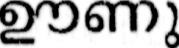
ഊണു
